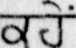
ਕਹੇਂ
